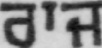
ਰਾਜ
